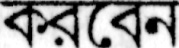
করবেন
